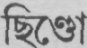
ছিণ্ডো
